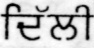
ਦਿੱਲੀ
